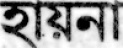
হায়না
